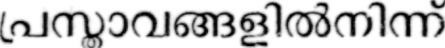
പ്രസ്താവങ്ങളില്‍നിന്ന്
